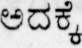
ಅದಕ್ಕೆ
